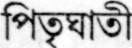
পিতৃঘাতী
